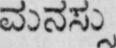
ಮನಸ್ಸು
